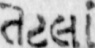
તેટલાં
